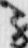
કે
